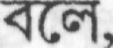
বলে,
